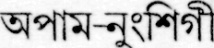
অপাম-নুংশিগী
